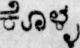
ಕೊಳ್ಳ
